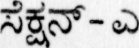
ಸೆಕ್ಷನ್-ಎ
